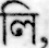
লি,
